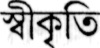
স্বীকৃতি
